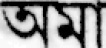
অমা
